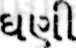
ઘણી
